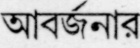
আবর্জনার
